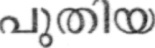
പുതിയ
